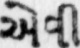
એવી
